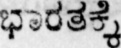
ಭಾರತಕ್ಕೆ
